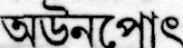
অউনপোৎ
